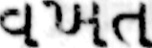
વખત
